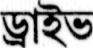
ড্রাইভ
